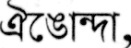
ঐঙোন্দা,
